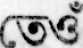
তেওঁ
